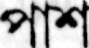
পাশ
